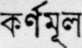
কর্ণমূল
